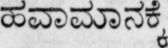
ಹವಾಮಾನಕ್ಕೆ
